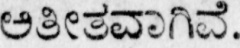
ಅತೀತವಾಗಿವೆ.
